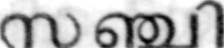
സഞ്ചി
